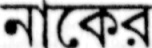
নাকের
